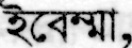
ইবেম্মা,
